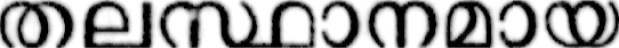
തലസ്ഥാനമായ
